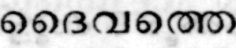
ദൈവത്തെ
